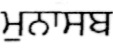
ਮੁਨਾਸਬ
